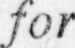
for
